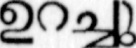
ഉറച്ചു
